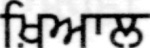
ਖ਼ਿਆਲ
